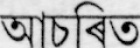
আচৰিত
